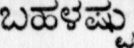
ಬಹಳಷ್ಟು
